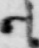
ન
